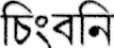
চিংবনি
